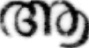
ആ
